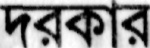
দরকার
